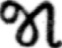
જા
